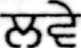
ਲਵੇ
